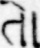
તો
